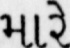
મારે
